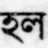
হল
